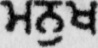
ਮਨੁਖ
